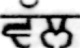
ਵੱਲ
